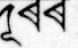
দূৰৰ
